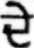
ਦੇ
